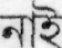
নাই
